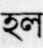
হল
